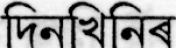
দিনখিনিৰ
